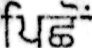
ਪਿਛੋਂ
